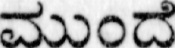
ಮುಂದೆ
